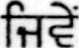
ਜਿਵੇਂ
